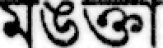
মঙক্তা
